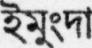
ইমুংদা
